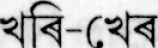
খৰি-খেৰ
